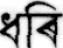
ধৰি
